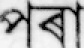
পৰা
